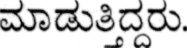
ಮಾಡುತ್ತಿದ್ದರು.
